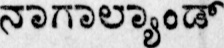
ನಾಗಾಲ್ಯಾಂಡ್
